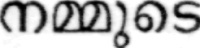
നമ്മുടെ
